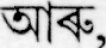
আৰু,
